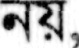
নয়,
